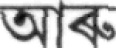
আৰু
